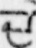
ਦ
